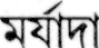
মর্যাদা
